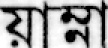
য়াম্না
